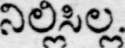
ನಿಲ್ಲಿಸಿಲ್ಲ.
